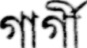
গার্গী
